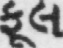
ફૂલ
